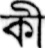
কী
